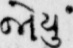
જોયું
